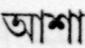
আশা
